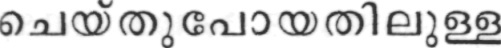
ചെയ്തുപോയതിലുള്ള
